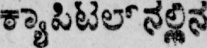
ಕ್ಯಾಪಿಟಲ್‌ನಲ್ಲಿನ
